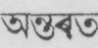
অন্তৰত
